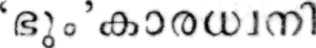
'ഭും'കാരധ്വനി
